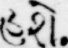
હશે.
